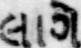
લાગે
